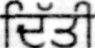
ਦਿੱਤੀ
